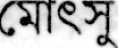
মোৎসু
